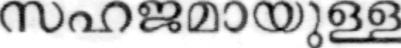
സഹജമായുള്ള
